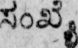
ಸಂಖ್ಯೆ
